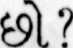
છો?
